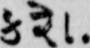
કરો.
